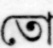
তো
